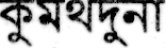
কুমথদুনা
